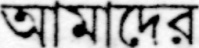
আমাদের
